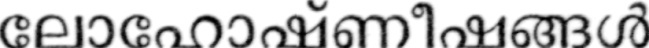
ലോഹോഷ്ണീഷങ്ങള്‍
